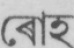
ৰোহ
